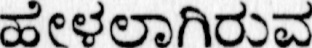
ಹೇಳಲಾಗಿರುವ
